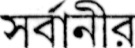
সর্বানীর
